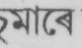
চুমাৰে
